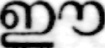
ഈ
